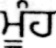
ਮੂੰਹ
